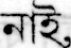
নাই,
